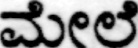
ಮೇಲೆ
